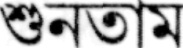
শুনতাম
